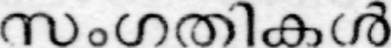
സംഗതികള്‍
